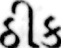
ઠીક
